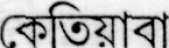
কেতিয়াবা
